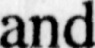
and
